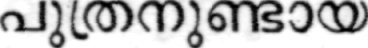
പുത്രനുണ്ടായ
